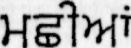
ਮਛੀਆਂ
